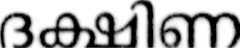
ദക്ഷിണ
